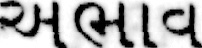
અભાવ
